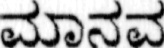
ಮಾನವ
